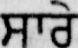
ਸਾਰੇ
